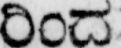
ರಿಂದ
